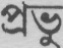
প্রভু
